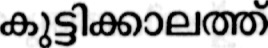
കുട്ടിക്കാലത്ത്
